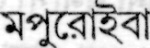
মপুরোইবা
